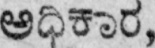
ಅಧಿಕಾರ,
